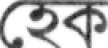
হেক
